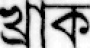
খ্রাক
